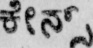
ಕೇನ್ಸ್
